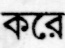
করে
